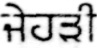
ਜੇਹੜੀ
